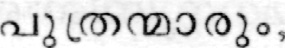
പുത്രന്മാരും,
